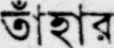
তাঁহার
